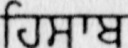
ਹਿਸਾਬ
